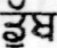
ਡੁੱਬ
